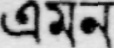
এমন
